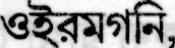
ওইরমগনি,
